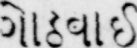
ગોઠવાઈ
